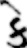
કે
